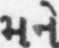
મને
